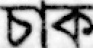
চাক
